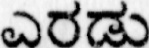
ಎರಡು
